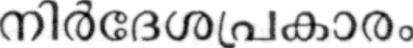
നിര്‍ദേശപ്രകാരം
